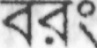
বরং
